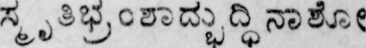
ಸ್ಮೃತಿಭ್ರಂಶಾದ್ಭುದ್ಧಿನಾಶೋ
